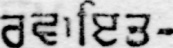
ਰਵਾਇਤ-
